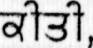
ਕੀਤੀ,
